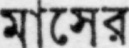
মাসের
